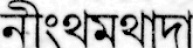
নীংথমথাদা
